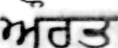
ਔਰਤ
